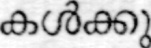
കള്‍ക്കു
